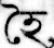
হৈ,
